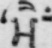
'ਮੈਂ
